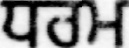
ਧਰਮ
